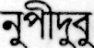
নুপীদুবু
